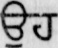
ਉਹ
